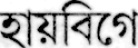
হায়বিগে
